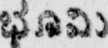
ಭೂಮಿ
